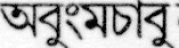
অবুংমচাবু
